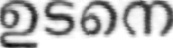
ഉടനെ
